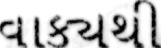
વાક્યથી
